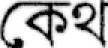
কেথ
